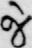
જે
